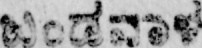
ಬ೦ಡವಾಳ
